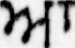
ਆ
